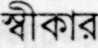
স্বীকার
